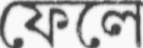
ফেলে
